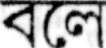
বলে
